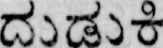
ದುಡುಕಿ
